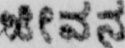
ಜೀವನ
